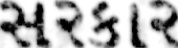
સરકાર
